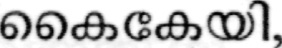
കൈകേയി,
